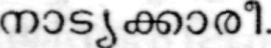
നാട്യക്കാരീ.
